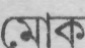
মোক
